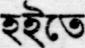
হইতে
